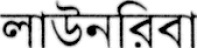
লাউনরিবা
